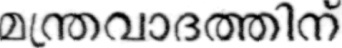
മന്ത്രവാദത്തിന്
